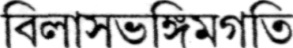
বিলাসভঙ্গিমগতি
